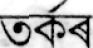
তর্কৰ
